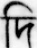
দি
